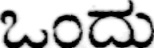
ಒಂದು
